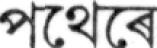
পথেৰে
